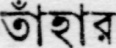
তাঁহার
